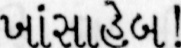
ખાંસાહેબ!
